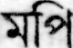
মপি
